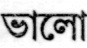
ভালো
